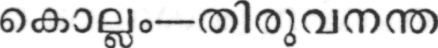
കൊല്ലം-തിരുവനന്ത
